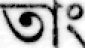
তাং
